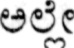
ಅಲ್ಲೇ
